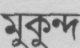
মুকুন্দ
